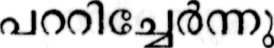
പററിച്ചേര്‍ന്നു
